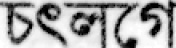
চৎলগে
